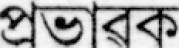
প্রভাৱক
